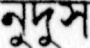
নুদুস
